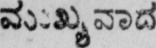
ಮುಖ್ಯವಾದ
